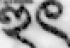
হুৎ
